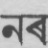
নৰ
